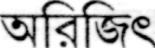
অরিজিৎ
